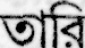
তারি
